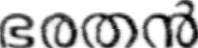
ഭരതന്‍
